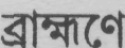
ব্ৰাহ্মণে
